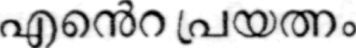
എന്റെപ്രയത്നം
